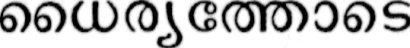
ധൈര്യത്തോടെ
